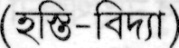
(হস্তি-বিদ্যা)
